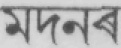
মদনৰ
